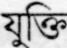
যুক্তি
